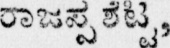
ರಾಜಪ್ಪಶೆಟ್ಟಿ,
